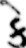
કે
